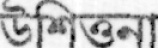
উশিত্তনা
